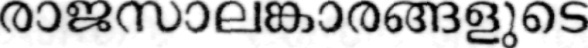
രാജസാലങ്കാരങ്ങളുടെ
